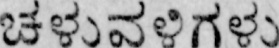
ಚಳುವಳಿಗಳು
